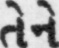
તેને
